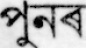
পুনৰ
